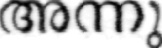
അന്നു
